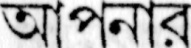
আপনার
